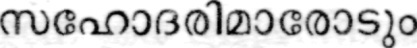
സഹോദരിമാരോടും
